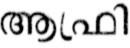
ആഫ്രി
